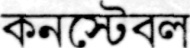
কনস্টেবল
